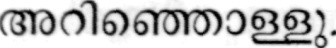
അറിഞ്ഞൊള്ളു.
